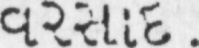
વરસાદ.
